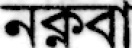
নক্নবা
